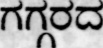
ಗಗ್ಗರದ
